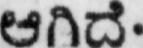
ಆಗಿದೆ.
